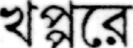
খপ্পরে
